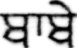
ਬਾਬੇ
